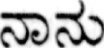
ನಾನು
